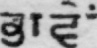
ਭਾਵੇਂ
